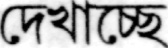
দেখাচ্ছে
